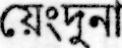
য়েংদুনা
